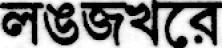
লঙজখরে
